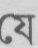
যে
